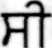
ਸੀ
